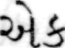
એક
